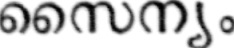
സൈന്യം
